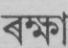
ৰক্ষা
